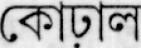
কোঢ়াল
